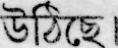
উঠিছে
